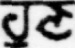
ਹੁਣ
